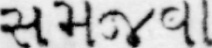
સમજવા
